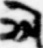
એ
